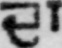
ਦਾ
